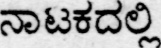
ನಾಟಕದಲ್ಲಿ
